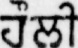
ਹੌਲੀ
